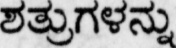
ಶತ್ರುಗಳನ್ನು
